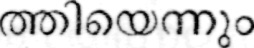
ത്തിയെന്നും
